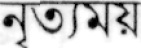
নৃত্যময়
